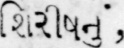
શિરીષનું,
